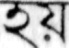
হয়
